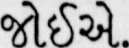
જોઈએ.
